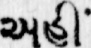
અહીં
